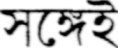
সঙ্গেই
